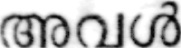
അവള്‍
